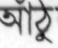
আঁঠু
